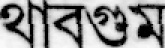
থাবগুম
